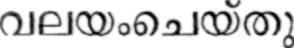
വലയംചെയ്തു
